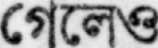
গেলেও
